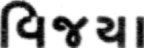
વિજયા
